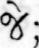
જે;
